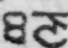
ਬਣ
